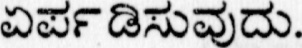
ಏರ್ಪಡಿಸುವುದು.
